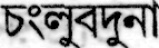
চংলুবদুনা
